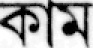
কাম
